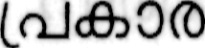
പ്രകാര
